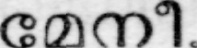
മേനീ.
